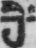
ਹੈਂ
